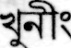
খুনীং
